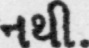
નથી.
